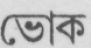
ভোক
